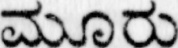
ಮೂರು
